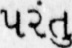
પરંતુ
